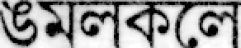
ঙমলকলে
